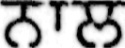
ਨਾਲ
